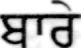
ਬਾਰੇ
